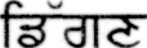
ਡਿੱਗਣ
